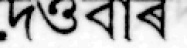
দেওবাৰ
